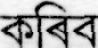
কৰিব
